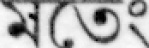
মতেং
